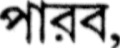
পারব,
